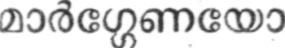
മാര്‍ഗ്ഗേണയോ
